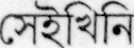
সেইখিনি
